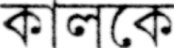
কালকে
